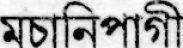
মচানিপাগী
